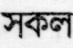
সকল
